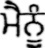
ਮੈਨੂੰ
